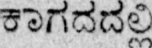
ಕಾಗದದಲ್ಲಿ
